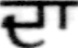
ਦਾ
